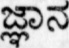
ಜ್ಞಾನ
